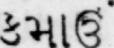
કમાઉં
